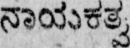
ನಾಯಕತ್ವ
